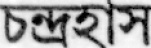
চন্দ্রহাস
